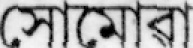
সোমোৱা
